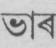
ভাৰ
